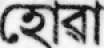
হোৱা
